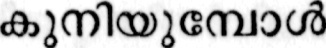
കുനിയുമ്പോള്‍
